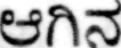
ಆಗಿನ
